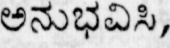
ಅನುಭವಿಸಿ,
